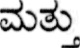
ಮತ್ತು
